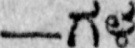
-ಗಳ
